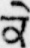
ਕੇ
